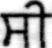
ਸੀ
